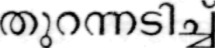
തുറന്നടിച്ച്
